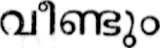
വീണ്ടും
